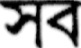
সব
